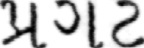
પ્રગટ
